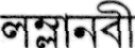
লম্লানবী
